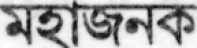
মহাজনক
